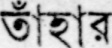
তাঁহার
